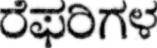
ರೆಫರಿಗಳ
